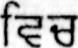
ਵਿਚ
